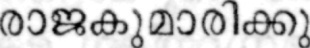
രാജകുമാരിക്കു
